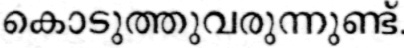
കൊടുത്തുവരുന്നുണ്ട്.
